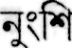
নুংশি
